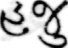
હજુ
